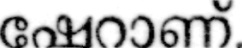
ഷേറാണ്.
